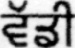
ਵੱਡੀ
